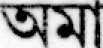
অমা
